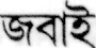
জবাই
